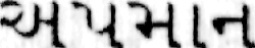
અપમાન
